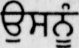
ਉਸਨੂੰ
